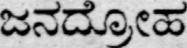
ಜನದ್ರೋಹ
